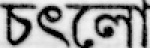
চৎলো
